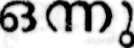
ഒന്നു
